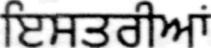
ਇਸਤਰੀਆਂ
